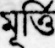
মূর্ত্তি
